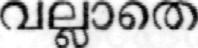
വല്ലാതെ
